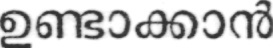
ഉണ്ടാക്കാന്‍
